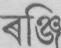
ৰঞ্জি
